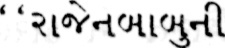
"રાજેનબાબુની
